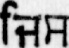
ਜਿਸ
